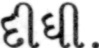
દીધી.
